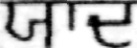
ਯਾਦ
